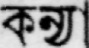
কন্যা
